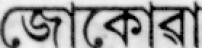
জোকোৱা
